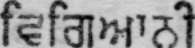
ਵਿਗਿਆਨੀ
